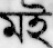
মই
